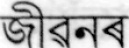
জীৱনৰ
